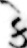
કે
